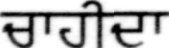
ਚਾਹੀਦਾ
